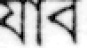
যাব
